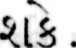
શકે.
